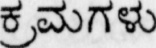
ಕ್ರಮಗಳು
